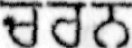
ਚਰਨ
